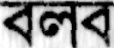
বলব
